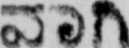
ವಾಗಿ
